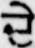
ਦੇ
